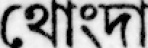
থোংদা
